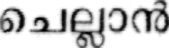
ചെല്ലാന്‍
